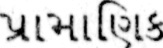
પ્રામાણિક
